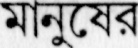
মানুষের
